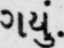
ગયું.
